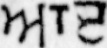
ਆਦ
